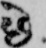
છે.
